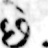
છે.
